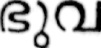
ഭുവ
